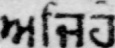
ਅਜਿਹੇ
